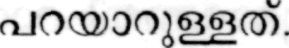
പറയാറുള്ളത്.
